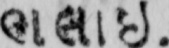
ભલાઈ.
